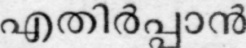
എതിര്‍പ്പാന്‍
